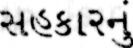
સહકારનું
